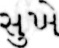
સુખે
